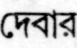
দেবার
